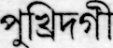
পুখ্রিদগী
